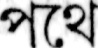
পথে
